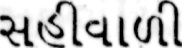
સહીવાળી
